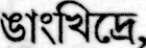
ঙাংখিদ্রে,
